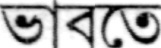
ভাবতে
